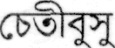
চেতীবুসু
